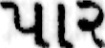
પાર
